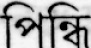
পিন্ধি
